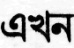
এখন
